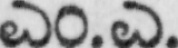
ಎಂ.ಎ.
